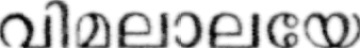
വിമലാലയേ
